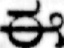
ಈ
